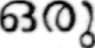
ഒരു
